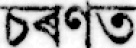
চৰণত
